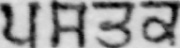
ਪੁਸਤਕ
